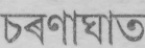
চৰণাঘাত
